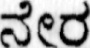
ನೇರ
